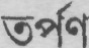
তৰ্পণ
